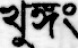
খুঙ্গং
